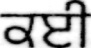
ਕਈ
